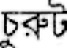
চুরুট
